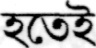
হতেই
